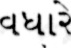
વધારે
